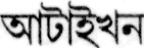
আটাইখন
